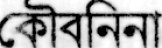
কৌবনিনা
